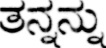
ತನ್ನನ್ನು
